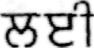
ਲਈ
